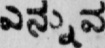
ಎನ್ನುವ
